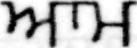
ਆਮ
